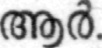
ആര്‍.
